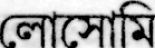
লোসোমি
